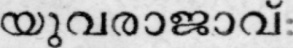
യുവരാജാവ്:
